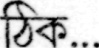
ঠিক...
